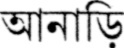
আনাড়ি
